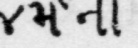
જર્મની
